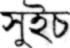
সুইচ
